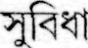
সুবিধা
